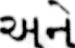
અને
